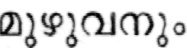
മുഴുവനും
